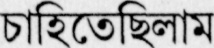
চাহিতেছিলাম
